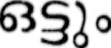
ഒട്ടും
